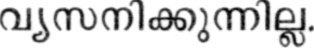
വ്യസനിക്കുന്നില്ല.
